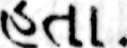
હતા.
